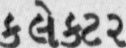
કલેક્ટર
